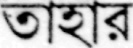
তাহার
